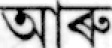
আৰু
